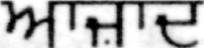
ਆਜ਼ਾਦ
